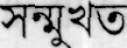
সন্মুখত
